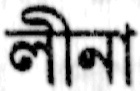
লীনা
